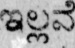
ಇಲ್ಲವೆ
